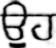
ਉਹ
